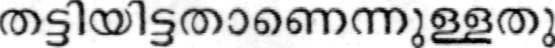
തട്ടിയിട്ടതാണെന്നുള്ളതു
